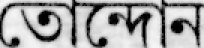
তোন্দোন
